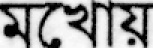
মখোয়
